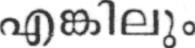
എങ്കിലും
